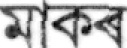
মাকৰ
